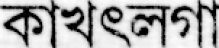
কাখৎলগা
